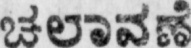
ಚಲಾವಣೆ
